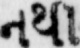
નથી
